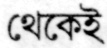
থেকেই
